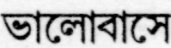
ভালোবাসে
